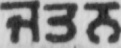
ਜਤਨ
